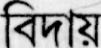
বিদায়
